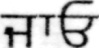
ਜਾਓ
